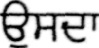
ਉਸਦਾ
